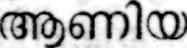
ആണിയ
